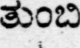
ತುಂಬಿ
